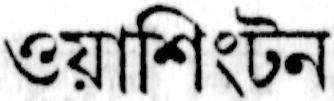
ওয়াশিংটন
